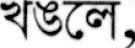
খঙলে,
